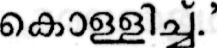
കൊള്ളിച്ച്.’
